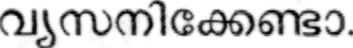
വ്യസനിക്കേണ്ടാ.
